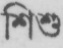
শিশু
